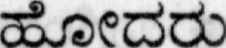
ಹೋದರು
